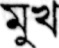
মুখ
